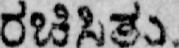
ರಚಿಸಿತು.
